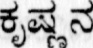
ಕೃಷ್ಣನ
